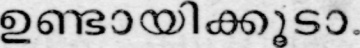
ഉണ്ടായിക്കൂടാ.
